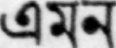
এমন
